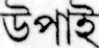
উপাই
